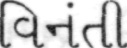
વિનંતી
